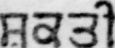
ਸ਼ਕਤੀ
